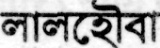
লালহৌবা
